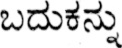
ಬದುಕನ್ನು
